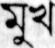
মুখ
